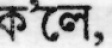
ক'লে,
